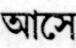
আসে
